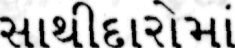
સાથીદારોમાં
